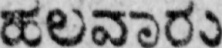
ಹಲವಾರು
